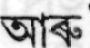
আৰু
